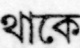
থাকে
